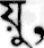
য়ু,
